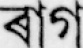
ৰাগ
